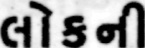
લોકની
